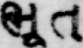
ભૂત
